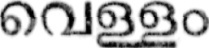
വെള്ളം
